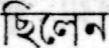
ছিলেন
